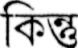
কিন্তু
